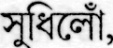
সুধিলোঁ,
